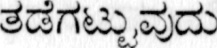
ತಡೆಗಟ್ಟುವುದು
